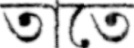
তাতে
